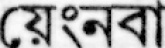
য়েংনবা
